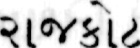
રાજકોટ
